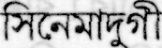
সিনেমাদুগী
